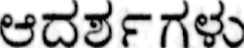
ಆದರ್ಶಗಳು
